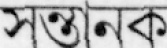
সন্তানক
